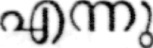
എന്നു
